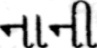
નાની
